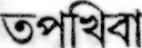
তপখিবা
